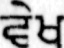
ਵੇਖ
